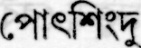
পোৎশিংদু
